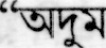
“অদুম
